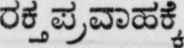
ರಕ್ತಪ್ರವಾಹಕ್ಕೆ
